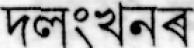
দলংখনৰ
